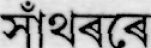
সাঁথৰৰে
